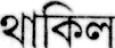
থাকিল
